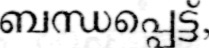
ബന്ധപ്പെട്ട്,
